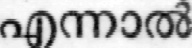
എന്നാല്‍
